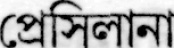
প্রেসিলানা
